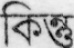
কিন্তু
